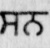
ਸਨ
